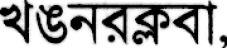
খঙনরক্লবা,
